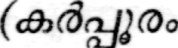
(കര്‍പ്പൂരം
